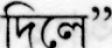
দিলে"
